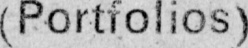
(Portfolios)
